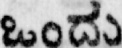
ಒಂದು
